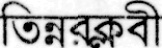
তিন্নরক্লবী
